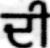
ਦੀ
